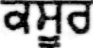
ਕਸੂਰ
